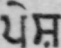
ਪੇਸ਼
